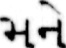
મને
